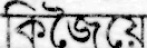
কিজৈয়ে
